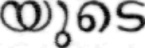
യുടെ
